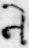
ને
